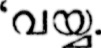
‘വയ്യ.
